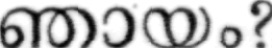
ഞായം?
